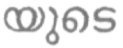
യുടെ
